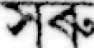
সৰু
